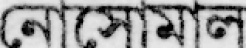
নোসোমাল
